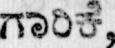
ಗಾರಿಕೆ,
